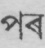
পৰ
